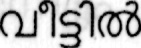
വീട്ടില്‍
